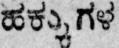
ಹಕ್ಕುಗಳ
